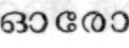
ഓരോ
